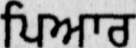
ਪਿਆਰ
